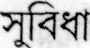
সুবিধা
